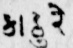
કાઠુરે
